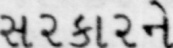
સરકારને
